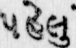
પહેલું
